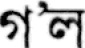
গ'ল
